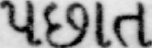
પછાત
